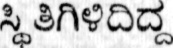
ಸ್ಥಿತಿಗಿಳಿದಿದ್ದ
